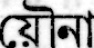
য়ৌনা
